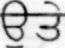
ਉਤੇ
